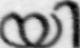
യി
